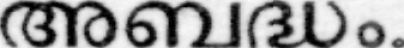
അബദ്ധം.
